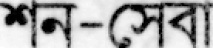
শন-সেবা
